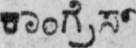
ಕಾಂಗ್ರೆಸ್
